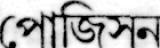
পোজিসন
